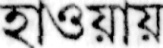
হাওয়ায়
